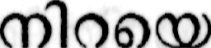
നിറയെ
